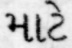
માટે
